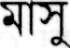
মাসু
